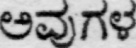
ಅವುಗಳ
